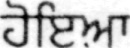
ਹੋਇਆ
